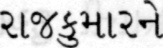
રાજકુમારને
